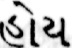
હોય
